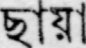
ছায়া
